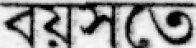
বয়সতে
